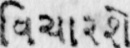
વિચારશે
